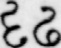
ર્દઢ
